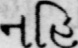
નહિ
